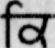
ਕਿ
